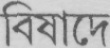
বিষাদে
